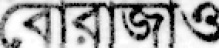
বোরাজাও
